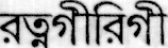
রত্নগীরিগী
